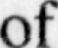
of
